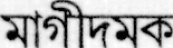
মাগীদমক
